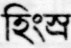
হিংস্র
